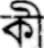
কী
